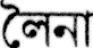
লৈনা
